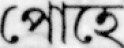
পোহে
